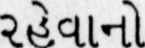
રહેવાનો
